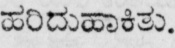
ಹರಿದುಹಾಕಿತು.
